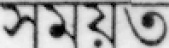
সময়ত
